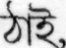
ঠাই,
